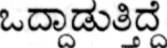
ಒದ್ದಾಡುತ್ತಿದ್ದೆ
